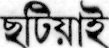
ছটিয়াই
